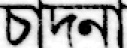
চাদনা
